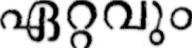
ഏറ്റവും
